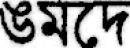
ঙমদে
